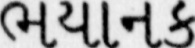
ભયાનાક
